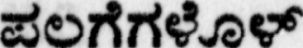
ಪಲಗೆಗಳೊಳ್
